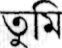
তুমি
